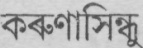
কৰুণাসিন্ধু
